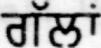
ਗੱਲਾਂ
